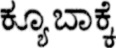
ಕ್ಯೂಬಾಕ್ಕೆ
